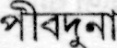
পীবদুনা
